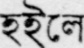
হইলে
